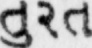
તુરત
